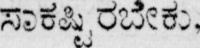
ಸಾಕಷ್ಟಿರಬೇಕು.
